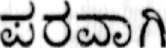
ಪರವಾಗಿ
